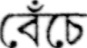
বেঁচে
